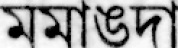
মমাঙদা
